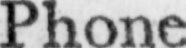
Phone
